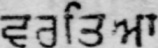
ਵਰਤਿਆ
